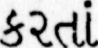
કરતાં
